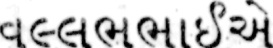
વલ્લભભાઈએ
